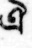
ঐ
